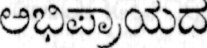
ಅಭಿಪ್ರಾಯದ
